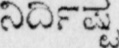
ನಿರ್ದಿಷ್ಟ
